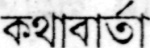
কথাবার্তা
